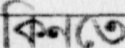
কিনতে
